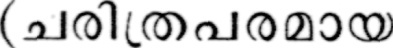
(ചരിത്രപരമായ
